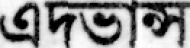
এদভান্স
